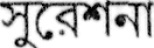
সুরেশনা
